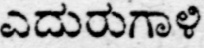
ಎದುರುಗಾಳಿ
